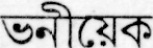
ভনীয়েক
